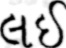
લઈ
